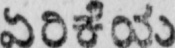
ಏರಿಕೆಯ
